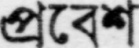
প্রবেশ
